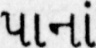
પાનાં
